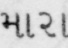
મારા
